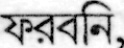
ফরবনি,
